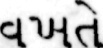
વખતે
